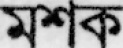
মশক
